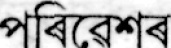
পৰিৱেশৰ
